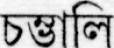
চম্ভালি
